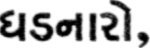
ધડનારો,
